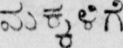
ಮಕ್ಕಳಿಗೆ
